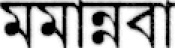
মমান্নবা
